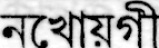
নখোয়গী
